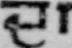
ਦਾ
